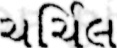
ચર્ચિલ
